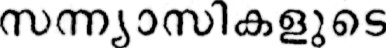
സന്ന്യാസികളുടെ
